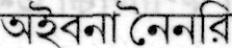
অইবনা
